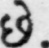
છે.
